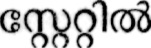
സ്റ്റേറ്റില്‍
